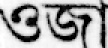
ওজা
